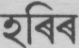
হৰিৰ
